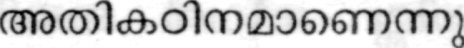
അതികഠിനമാണെന്നു
